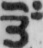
ਤੋਂ
